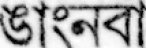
ঙাংনবা
